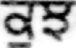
ਕੁਝ
